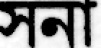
সনা
